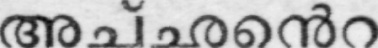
അച്ഛന്റെ
